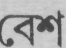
বেশ
